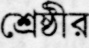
শ্রেষ্ঠীর
